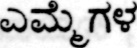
ಎಮ್ಮೆಗಳ
